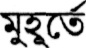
মুহর্তে
